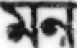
মন
